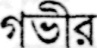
গভীর
